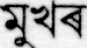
মুখৰ
